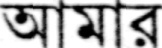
আমার
